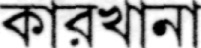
কারখানা
